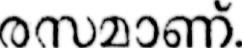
രസമാണ്.
